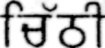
ਚਿੱਠੀ
